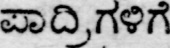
ಪಾದ್ರಿಗಳಿಗೆ
